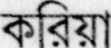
করিয়া
